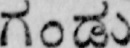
ಗಂಡು
